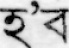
হ'ব
